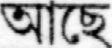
আছে
